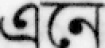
এনে
